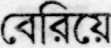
বেরিয়ে
